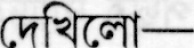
দেখিলো-
